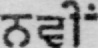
ਨਵੀਂ
